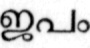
ജപം
